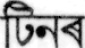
টিনৰ
